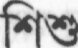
শিশু
